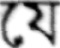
যে
